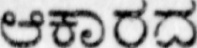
ಆಕಾರದ
